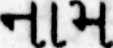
નામ
